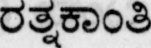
ರತ್ನಕಾಂತಿ
